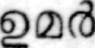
ഉമര്‍
